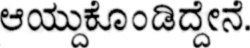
ಆಯ್ದುಕೊಂಡಿದ್ದೇನೆ.
